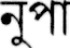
নুপা
